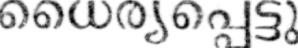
ധൈര്യപ്പെട്ടു
